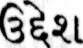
ઉદ્દેશ
